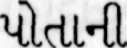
પોતાની
